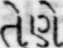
તેણે
